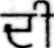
ਦੀ
